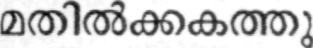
മതില്‍ക്കകത്തു
